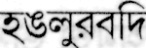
হঙলুরবদি
